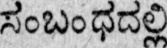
ಸಂಬಂಧದಲ್ಲಿ
